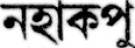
নহাকপু
